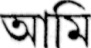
আমি
